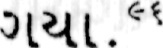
ગયા.૯૬
